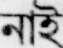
নাই
